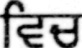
ਵਿਚ
